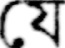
যে
